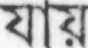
যায়
